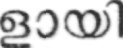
ളായി
